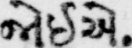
જોઈએ.
